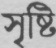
সৃষ্টি
